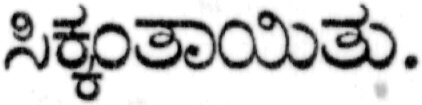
ಸಿಕ್ಕಂತಾಯಿತು.
